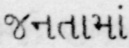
જનતામાં
